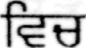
ਵਿਚ
